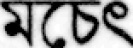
মচেৎ
